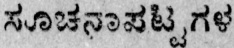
ಸೂಚನಾಪಟ್ಟಿಗಳ
